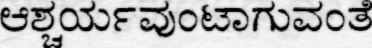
ಆಶ್ಚರ್ಯವುಂಟಾಗುವಂತೆ
